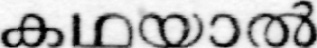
കഥയാല്‍
